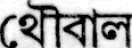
থৌবাল
